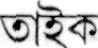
তাইক
